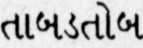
તાબડતોબ
